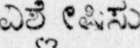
ವಿಶ್ಲೇಷಿಸು
